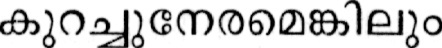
കുറച്ചുനേരമെങ്കിലും
